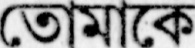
তোমাকে
